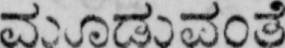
ಮೂಡುವಂತೆ
